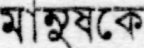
মানুষকে
